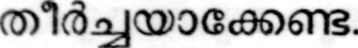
തീര്‍ച്ചയാക്കേണ്ട.
